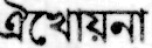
ঐখোয়না
